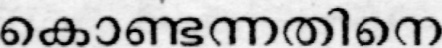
കൊണ്ടന്നതിനെ
